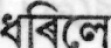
ধৰিলে
